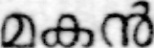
മകന്‍
